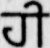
ਹੀ
